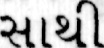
સાથી
